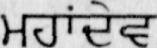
ਮਹਾਂਦੇਵ
